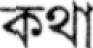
কথা
